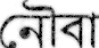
নৌবা
